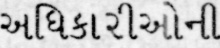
અધિકારીઓની
